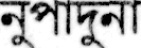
নুপাদুনা
